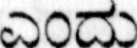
ಎಂದು
